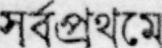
সর্বপ্রথমে
